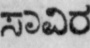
ಸಾವಿರ
